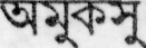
অমুকসু
